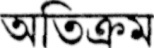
অতিক্রম
